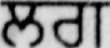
ਲਗ
